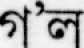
গ'ল
